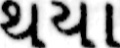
થયા
